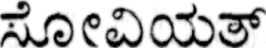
ಸೋವಿಯತ್
